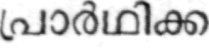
പ്രാര്‍ഥിക്ക
